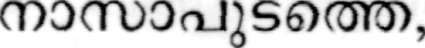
നാസാപുടത്തെ,
